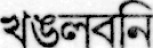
খঙলবনি
